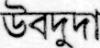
উবদুদা
